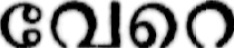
വേറെ
